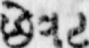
છેવટ
